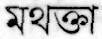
মথক্তা
